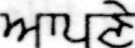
ਆਪਣੇ
